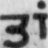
ਤਾਂ
